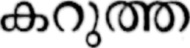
കറുത്ത
